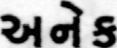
અનેક
